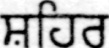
ਸ਼ਹਿਰ
